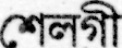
শেলগী
